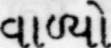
વાળ્યો
